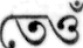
তেওঁ
